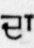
ਦਾ
